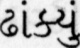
ઢાંક્યું
